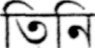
তিনি
